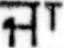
ਜਾ
